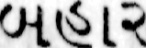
બહાર
